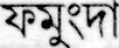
ফমুংদা
